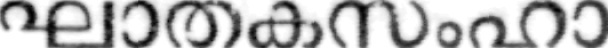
ഘാതകസംഹാ
